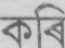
কৰি
